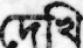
দেখি
